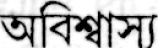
অবিশ্বাস্য
